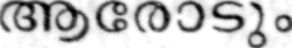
ആരോടും
